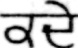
ਕਦੇ
